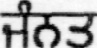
ਜੰਨਤ
